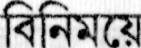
বিনিময়ে
